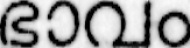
ഭാവം
